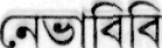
নেভাবিবি
